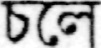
চলে
